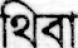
থিবা
